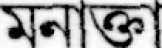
মনাক্তা
